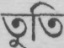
তুতি
